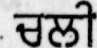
ਚਲੀ
